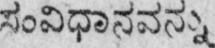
ಸಂವಿಧಾನವನ್ನು
